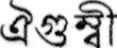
ঐগুম্বী
